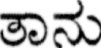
ತಾನು
